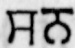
ਸਨ
